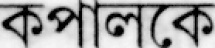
কপালকে
